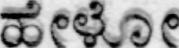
ಹೇಳೋ
